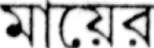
মায়ের
